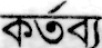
কর্তব্য
